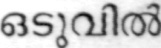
ഒടുവില്‍
